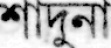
শাদুনা
